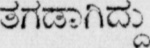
ತಗಡಾಗಿದ್ದು
